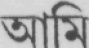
আমি
